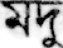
মদু
